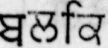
ਬਲਕਿ
